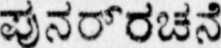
ಪುನರ್‌ರಚನೆ
